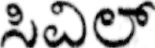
ಸಿವಿಲ್
